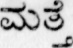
ಮತ್ತೆ
